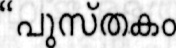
"പുസ്തകം
